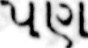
પણ
